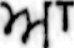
ਆ
